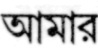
আমার
